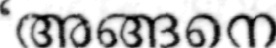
'അങ്ങനെ
